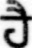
ਹੈ
